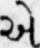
એ
